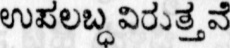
ಉಪಲಬ್ಧವಿರುತ್ತವೆ
